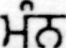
ਮੰਨ
